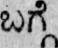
ಬಗ್ಗೆ
